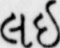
લઈ
